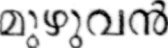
മുഴുവന്‍
